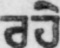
ਰਹੇ
